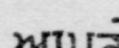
ਆਪਣੇ
